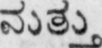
ಮತ್ತು
